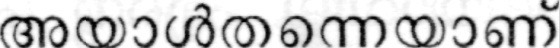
അയാള്‍തന്നെയാണ്
